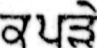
ਕਪੜੇ
